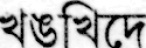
খঙখিদে
